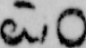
ಎಂ
